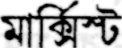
মার্ক্সিস্ট
